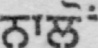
ਨਾਲੋਂ
